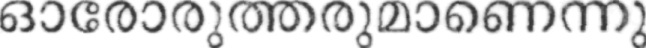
ഓരോരുത്തരുമാണെന്നു
